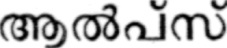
ആല്‍പ്സ്
